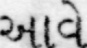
આવે
